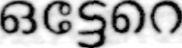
ഒട്ടേറെ
